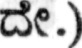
ದೇ.)
